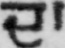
ਦਾ
